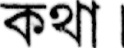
কথা।
